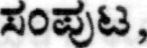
ಸಂಪುಟ,
